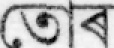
তোৰ
